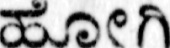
ಹೋಗಿ
